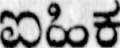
ಐಹಿಕ
